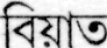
বিয়াত
